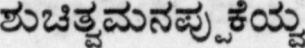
ಶುಚಿತ್ವಮನಪ್ಪುಕೆಯ್ವ
